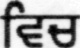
ਵਿਚ
